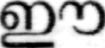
ഈ
